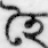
হৈ
